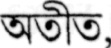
অতীত,
